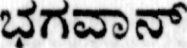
ಭಗವಾನ್
